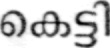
കെട്ടി
